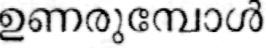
ഉണരുമ്പോള്‍
